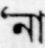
‘না
